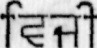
ਵਿਜੀ
